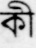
কী
